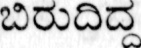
ಬಿರುದಿದ್ದ
